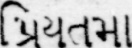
પ્રિયતમા
